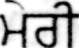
ਮੇਰੀ
